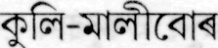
কুলি-মালীবোৰ
